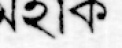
মহাক
